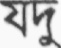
যদু
